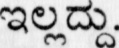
ಇಲ್ಲದ್ದು.
